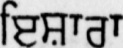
ਇਸ਼ਾਰਾ
